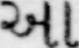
આ
